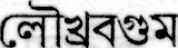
লৌখ্রবগুম
